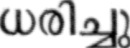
ധരിച്ചു
